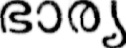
ഭാര്യ
